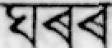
ঘৰৰ
